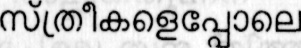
സ്ത്രീകളെപ്പോലെ
